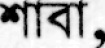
শাবা,
